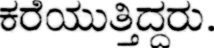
ಕರೆಯುತ್ತಿದ್ದರು.
